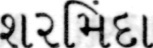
શરમિંદા
